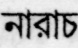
নারাচ
